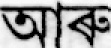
আৰু
